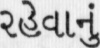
રહેવાનું
